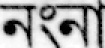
নংনা
